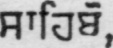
ਸਾਹਿਬੋ,
